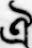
ঐ
